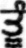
ਤੂੰ
